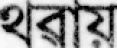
থৱায়
